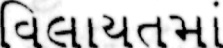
વિલાયતમાં
